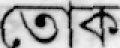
তোক
